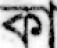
কা
